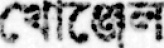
খোঞ্জেল
